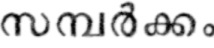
സമ്പര്‍ക്കം
